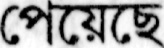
পেয়েছে
